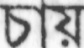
চায়
